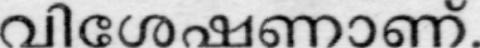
വിശേഷണാണ്.
